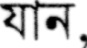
যান,
